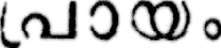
പ്രായം
